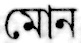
মোন
